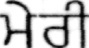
ਮੇਰੀ
